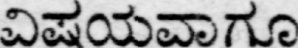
ವಿಷಯವಾಗೂ
